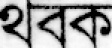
থবক
